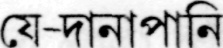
যে-দানাপানি
